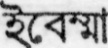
ইবেম্মা
